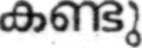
കണ്ടു
